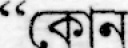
"কোন
